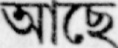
আছে
